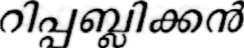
റിപ്പബ്ലിക്കന്‍
